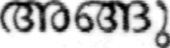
അങ്ങു
